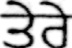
ਤੇਰੇ
